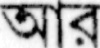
আর
